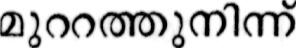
മുററത്തുനിന്ന്
